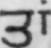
ਤਾਂ
